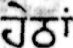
ਹੇਠਾਂ
